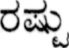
ರಷ್ಟು
